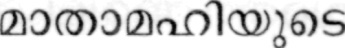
മാതാമഹിയുടെ
